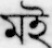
মই
